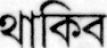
থাকিব
